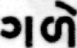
ગળે
